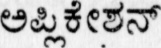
ಅಪ್ಲಿಕೇಶನ್
